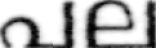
പല
